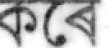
কৰে
